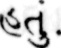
હતું.
